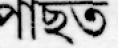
পাছত
